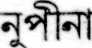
নুপীনা
